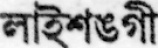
লাইশঙগী
